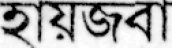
হায়জবা
